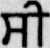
ਸੀ
